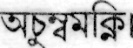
অচুম্বমক্নি।
